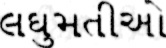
લઘુમતીઓ
